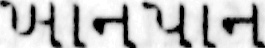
ખાનપાન
